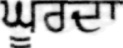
ਘੂਰਦਾ
